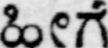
ಹೀಗೆ
